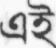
এই
